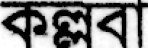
কল্লবা
